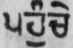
ਪਹੁੰਚੇ
